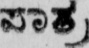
ಪಾತ್ರ
